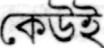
কেউই
